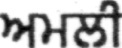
ਅਮਲੀ
